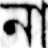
না
